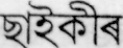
ছাইকীৰ
